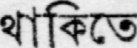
থাকিতে
